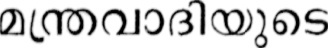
മന്ത്രവാദിയുടെ
